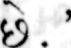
છે.'
